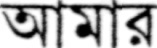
আমার
